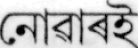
নোৱাৰই
